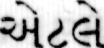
એટલે
